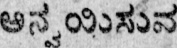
ಅನ್ವಯಿಸುವ
